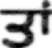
ਤਾਂ
